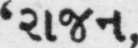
'રાજન્,
